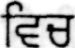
ਵਿਚ
